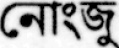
নোংজু
